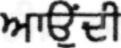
ਆਉਂਦੀ
